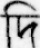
দি
